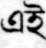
এই
